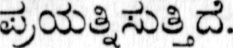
ಪ್ರಯತ್ನಿಸುತ್ತಿದೆ.
